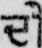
ਦੀ
